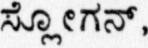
ಸ್ಲೋಗನ್,
